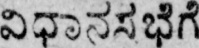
ವಿಧಾನಸಭೆಗೆ
